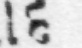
યાદ
